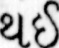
થઈ
